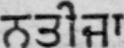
ਨਤੀਜਾ
